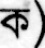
ক)
